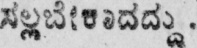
ಸಲ್ಲಬೇಕಾದದ್ದು.
